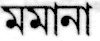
মমানা
